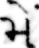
મેં
